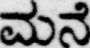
ಮನೆ
